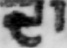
ਦਾ
